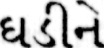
ઘડીને
